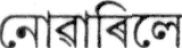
নোৱাৰিলে
